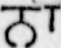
ਨਾ
